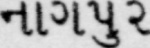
નાગપુર
